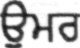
ਉਮਰ
